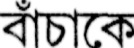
বাঁচাকে
